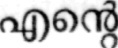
എന്റെ
